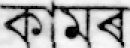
কামৰ
